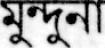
মুন্দুনা
